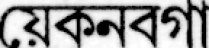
য়েকনবগা
